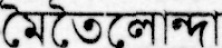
মৈতৈলোন্দা
